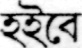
হইবে
